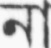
না
